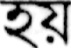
হয়
